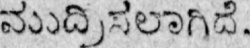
ಮುದ್ರಿಸಲಾಗಿದೆ.
